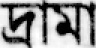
দ্রামা
